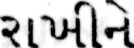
રાખીને
